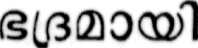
ഭദ്രമായി
